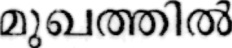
മുഖത്തില്‍
